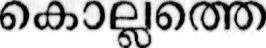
കൊല്ലത്തെ
